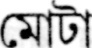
মোটা
